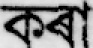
কৰা
